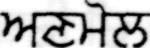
ਅਣਮੋਲ
